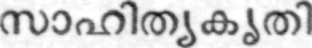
സാഹിത്യകൃതി
